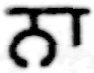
ਨਾ
